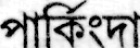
পার্কিংদা
